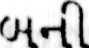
બની
